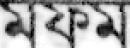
মফম
